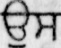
ਉਸ
